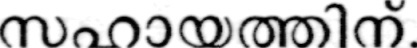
സഹായത്തിന്.
